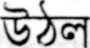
উঠল
